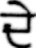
ਦੇ
